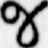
જ
